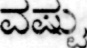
ವಷ್ಟು
